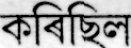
কৰিছিল
